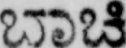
ಬಾಚಿ
